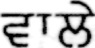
ਵਾਲੇ
